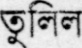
তুলিল
